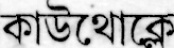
কাউথোক্লে
